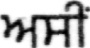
ਅਸੀਂ
